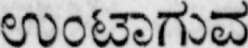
ಉಂಟಾಗುವ
